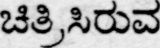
ಚಿತ್ರಿಸಿರುವ
